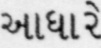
આધારે
